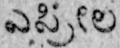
ಎಪ್ರೀಲ
